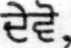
ਦੇਵੋ,
